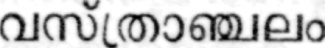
വസ്ത്രാഞ്ചലം
